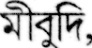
মীবুদি,
